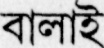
বালাই
